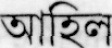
আহিল
